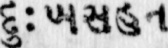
દુઃખસહન
